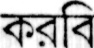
করবি
